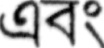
এবং
